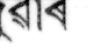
দুৱাৰ
